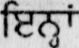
ਇਨ੍ਹਾਂ
